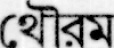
থৌরম
